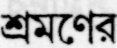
শ্রমণের
